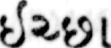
ઇચ્છા
